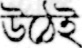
উঠেই
